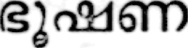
ഭൂഷണ
